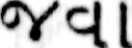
જવા
